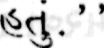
હતું."
